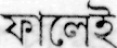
ফালেই
